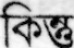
কিন্তু
